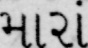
મારાં
